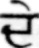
ਦੇ
